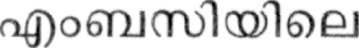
എംബസിയിലെ
